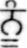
ਨੂੰ
